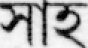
সাহ
